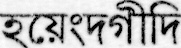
হয়েংদগীদি
